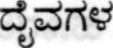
ದೈವಗಳ
